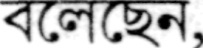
বলেছেন,
